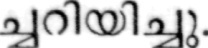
ച്ചറിയിച്ചു.
